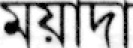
ময়াদা
